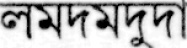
লমদমদুদা
